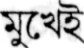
মুখেই
